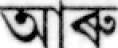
আৰু
